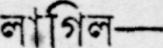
লাগিল—
